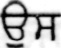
ਉਸ
